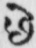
છે
